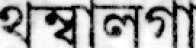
থম্বালগা
